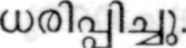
ധരിപ്പിച്ചു.
